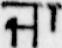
ਜਾ
